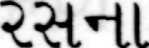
રસના
